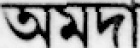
অমদা
